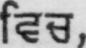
ਵਿਚ,
